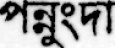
পন্নুংদা
